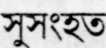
সুসংহত
